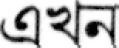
এখন
